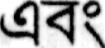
এবং
